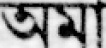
অমা
